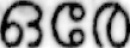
ഒരേ
